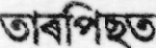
তাৰপিছত
